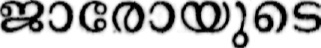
ജാരോയുടെ
